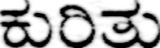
ಕುರಿತು
